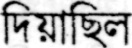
দিয়াছিল
